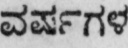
ವರ್ಷಗಳ
